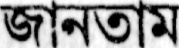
জানতাম
